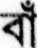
বাঁ
